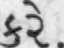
કરે.
